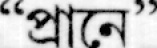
“প্রানে”
